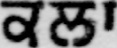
ਕਲਾ
